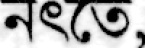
নৎতে,
